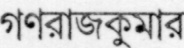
গণরাজকুমার
